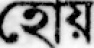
হোয়
